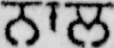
ਨਾਲ
